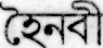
হৈনবী
